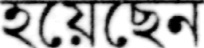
হয়েছেন
